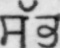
ਸੱਭ
